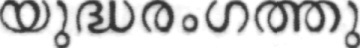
യുദ്ധരംഗത്തു
